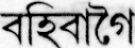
বহিবাগৈ
